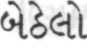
બેઠેલો
